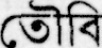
তৌবি
